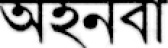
অহনবা
